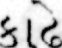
કાઢે
